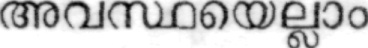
അവസ്ഥയെല്ലാം
